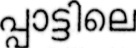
പ്പാട്ടിലെ
